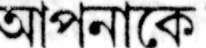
আপনাকে
